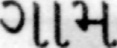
ગામ
